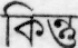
কিন্তু
